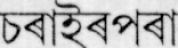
চৰাইৰপৰা
